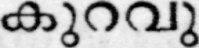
കുറവു
